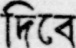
দিবে
